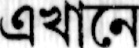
এখানে
